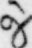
જે
